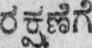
ರಕ್ಷಣೆಗೆ
